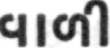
વાળી
